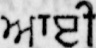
ਆਈ
